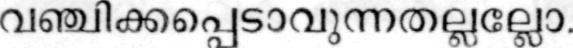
വഞ്ചിക്കപ്പെടാവുന്നതല്ലല്ലോ.
